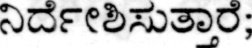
ನಿರ್ದೇಶಿಸುತ್ತಾರೆ;
